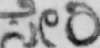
ಸೇರಿ
